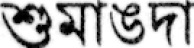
শুমাঙদা
